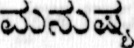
ಮನುಷ್ಯ
